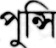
পুন্সি
